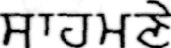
ਸਾਹਮਣੇ
